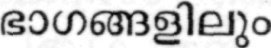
ഭാഗങ്ങളിലും
